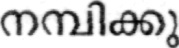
നമ്പിക്കു
